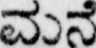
ಮನೆ
